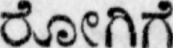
ರೋಗಿಗೆ
